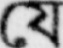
যে
